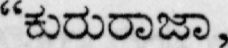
“ಕುರುರಾಜಾ,
